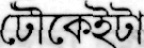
টৌকেইটা
